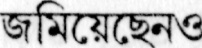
জমিয়েছেনও
